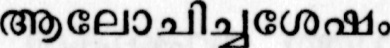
ആലോചിച്ചശേഷം
